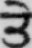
ਤੇ
